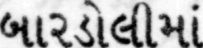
બારડોલીમાં
